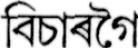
বিচাৰগৈ
